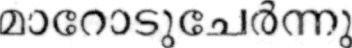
മാറോടുചേര്‍ന്നു
